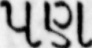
પણ
